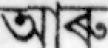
আৰু
